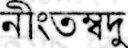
নীংতম্বদু
